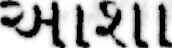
આશા
